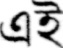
এই
